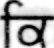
ਕਿ
